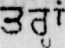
ਤਰ੍ਹਾਂ
